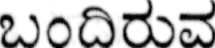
ಬಂದಿರುವ
